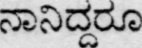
ನಾನಿದ್ದರೂ
